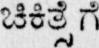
ಚಿಕಿತ್ಸೆಗೆ
